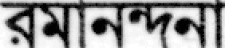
রমানন্দনা
